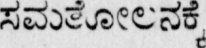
ಸಮತೋಲನಕ್ಕೆ
